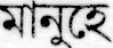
মানুহে
